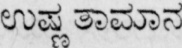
ಉಷ್ಣತಾಮಾನ
